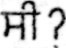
ਸੀ?
